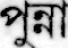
পু্ন্না
